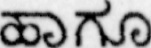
ಹಾಗೂ
